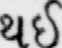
થઈ
